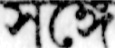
সঙ্গে
